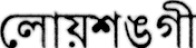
লোয়শঙগী
